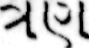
ત્રણ
